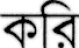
করি
